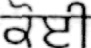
ਕੋਈ
